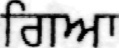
ਗਿਆ
